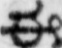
ಈ
